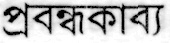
প্রবন্ধকাব্য
